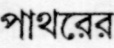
পাথরের
